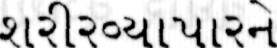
શરીરવ્યાપારને
